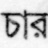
চার
